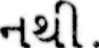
નથી.
